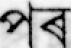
পৰ
